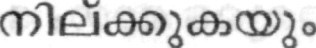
നില്ക്കുകയും
